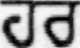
ਹਰ
